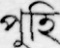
পুহি
